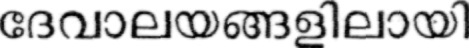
ദേവാലയങ്ങളിലായി
